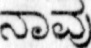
ನಾವು
